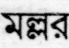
মল্লর
